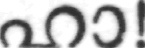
ഹാ!
